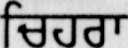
ਚਿਹਰਾ
